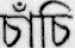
চাঁচি
